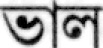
ভাল
